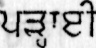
ਪੜ੍ਹਾਈ
